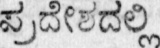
ಪ್ರದೇಶದಲ್ಲಿ
